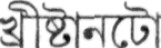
খ্ৰীষ্টানটো
